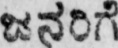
ಜನರಿಗೆ
